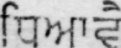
ਧਿਆਵੈ
